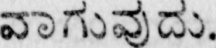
ವಾಗುವುದು.
